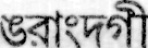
ঙরাংদগী
